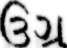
ઉગ્ર
